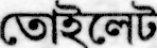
লোইলেট
